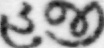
હજી
